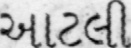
આટલી
